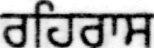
ਰਹਿਰਾਸ
